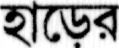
হাড়ের
